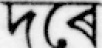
দৰে
